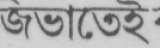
জিভাতেই
